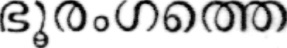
ഭൂരംഗത്തെ
